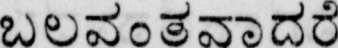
ಬಲವಂತವಾದರೆ
